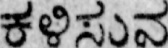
ಕಳಿಸುವ
